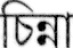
চিন্না
